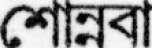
শোন্নবা
